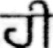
ਹੀ
